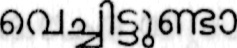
വെച്ചിട്ടുണ്ടാ
